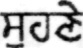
ਸੁਹਣੇ
